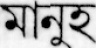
মানুহ
